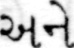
અને
